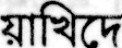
য়াখিদে
